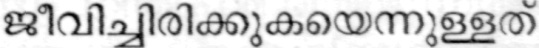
ജീവിച്ചിരിക്കുകയെന്നുള്ളത്
